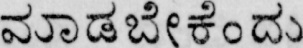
ಮಾಡಬೇಕೆಂದು
